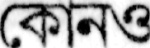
কোনও
